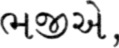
ભજીએ,
